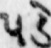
પડે
